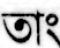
তাং
